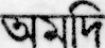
অমদি
